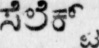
ಸೆಲೆಕ್ಟ್
